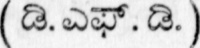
(ಡಿ.ಎಫ್.ಡಿ.)
